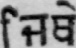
ਜਿਥੇ
